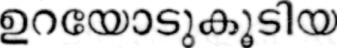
ഉറയോടുകൂടിയ
